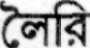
লৈরি
